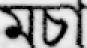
মচা
